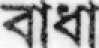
বাধা
